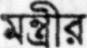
মন্ত্রীর
